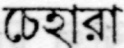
চেহারা
